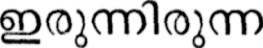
ഇരുന്നിരുന്ന
